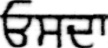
ਓਸਦਾ
